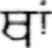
ਥਾਂ
